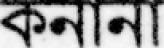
কনানা
